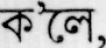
ক'লে,
